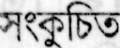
সংকুচিত
